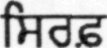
ਸਿਰਫ਼
